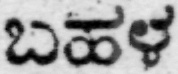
ಬಹಳ
